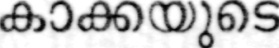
കാക്കയുടെ
